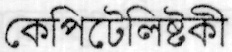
ঈশৈশিংদি
